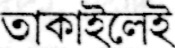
তাকাইলেই
